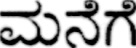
ಮನೆಗೆ
